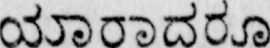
ಯಾರಾದರೂ
